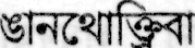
ঙানথোক্ত্রিবা
